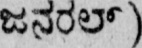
ಜನರಲ್)
